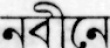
নবীনে
